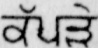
ਕੱਪੜੇ
